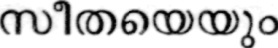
സീതയെയും
